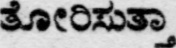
ತೋರಿಸುತ್ತಾ
